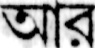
আর
